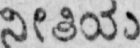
ನೀತಿಯ
